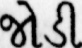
જોડી
